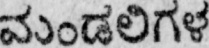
ಮಂಡಲಿಗಳ
